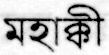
মহাক্কী
